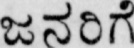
ಜನರಿಗೆ
